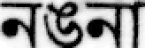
নঙনা
